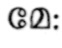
മേ:
